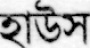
হাউস
